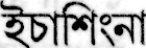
ইচাশিংনা
